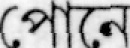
পোনে
